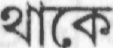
থাকে
